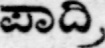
ಪಾದ್ರಿ
